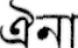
ঐনা
